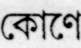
কোণে
